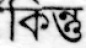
'কিন্তু
